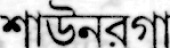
শাউনরগা
